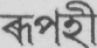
ৰূপহী
